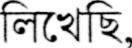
লিখেছি,
